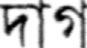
দাগ
